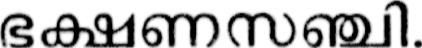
ഭക്ഷണസഞ്ചി.
